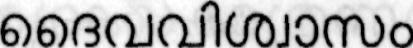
ദൈവവിശ്വാസം
